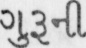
ગુરૂની
